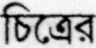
চিত্রের
